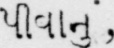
પીવાનું,
